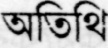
অতিথি
